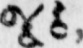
જૂઠ,
